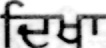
ਦਿਖਾ
